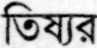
তিষ্যর
